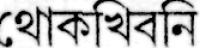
থোকখিবনি
